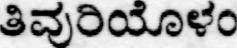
ತಿವುರಿಯೊಳ೦
